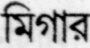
মিগার
